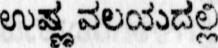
ಉಷ್ಣವಲಯದಲ್ಲಿ
